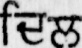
ਦਿਲ
